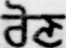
ਰੋਣ
